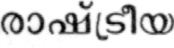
രാഷ്ട്രീയ
